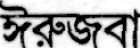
ঈরুজবা
